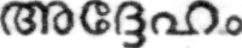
അദ്ദേഹം
